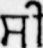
ਸੀ
